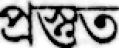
প্রস্তুত
